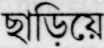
ছাড়িয়ে
